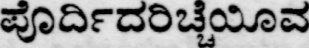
ಪೊರ್ದಿದರಿಚ್ಚೆಯಿವ
